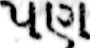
પણ
